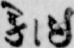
કોઈ
